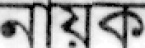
নায়ক
